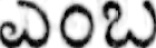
ಎಂಬ
